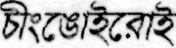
চীংঙোইরোই
